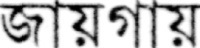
জায়গায়
